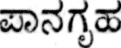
ಪಾನಗೃಹ
